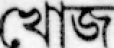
খোজ
